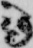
છે
